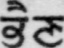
ਭੈਣ
